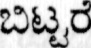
ಬಿಟ್ಟರೆ
